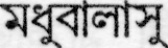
মধুবালাসু
